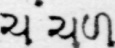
ચંચળ
